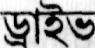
ড্রাইভ
